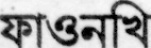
ফাওনখি
